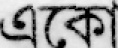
একো
